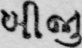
બીજુ
